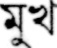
মুখ
